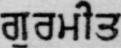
ਗੁਰਮੀਤ
